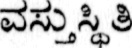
ವಸ್ತುಸ್ಥಿತಿ
